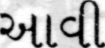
આવી
